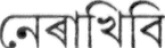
নেৰাখিবি
